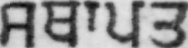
ਸਥਾਪਤ
